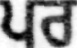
ਪਰ
